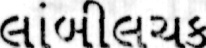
લાંબીલચક
